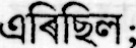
এৰিছিল;
